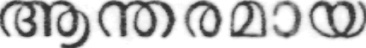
ആന്തരമായ
